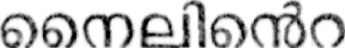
നൈലിന്റെ
